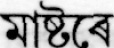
মাষ্টৰে
